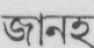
জানহ
